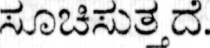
ಸೂಚಿಸುತ್ತದೆ.
